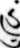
હું
